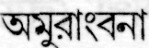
অমুরাংবনা
